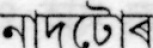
নাদটোৰ
